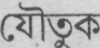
যৌতুক
